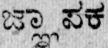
ಜ್ಞಾಪಕ
